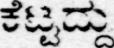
ಕೆಟ್ಟದ್ದು
